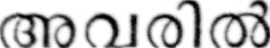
അവരില്‍
